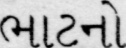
ભાટનો
